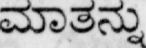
ಮಾತನ್ನು
